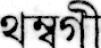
থম্বগী
